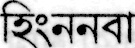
হিংননবা
